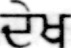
ਦੇਖ
